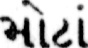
મોટાં
